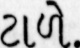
ટાળે.
